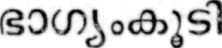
ഭാഗ്യംകൂടി
